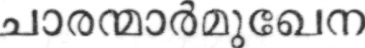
ചാരന്മാര്‍മുഖേന
